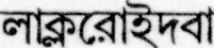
লাক্লরোইদবা
